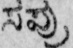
ಸಪ್ರು
